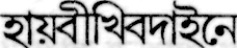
হায়বীখিবদাইনে
